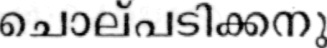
ചൊല്പടിക്കനു
